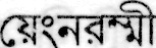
য়েংনরম্মী
